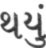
થયું
